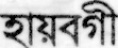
হায়বগী
